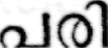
പരി
